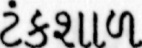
ટંકશાળ
